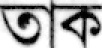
তাক
